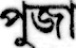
পুজা
